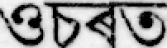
ওচৰত
